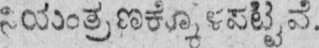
ನಿಯಂತ್ರಣಕ್ಕೊಳಪಟ್ಟಿವೆ.
